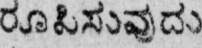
ರೂಪಿಸುವುದು
